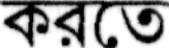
করতে
